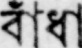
বাঁধা
